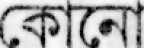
কোনো
